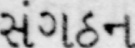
સંગઠન
